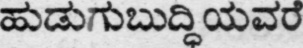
ಹುಡುಗುಬುದ್ಧಿಯವರೆ
